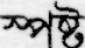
স্পষ্ট
